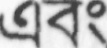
এবং
